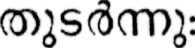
തുടര്‍ന്നു:
